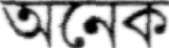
অনেক
